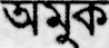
অমুক
